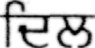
ਦਿਲ
